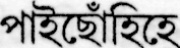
পাইছোঁহিহে
